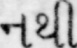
નથી
